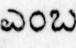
ಎಂಬ
